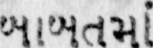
બાબતમાં
